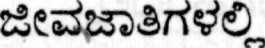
ಜೀವಜಾತಿಗಳಲ್ಲಿ
